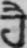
ਹੈ
